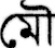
মৌ
